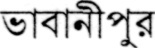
ভাবানীপুর
